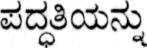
ಪದ್ಧತಿಯನ್ನು
